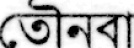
তৌনবা
